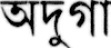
অদুগা
